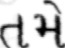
તમે
